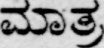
ಮಾತ್ರ
